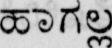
ಹಾಗಲ್ಲ
